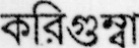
করিগুম্বা
